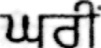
ਘਰੀਂ
